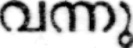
വന്നു
